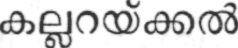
കല്ലറയ്ക്കല്‍
